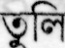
তুলি
